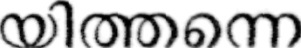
യിത്തന്നെ
